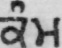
ਕੰਮ
